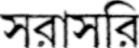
সরাসরি
